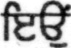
ਇਉਂ
